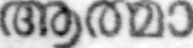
ആത്മാ
